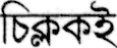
চিক্লকই
